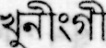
খুনীংগী
